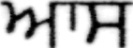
ਆਸ
